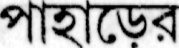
পাহাড়ের
